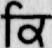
ਕਿ
